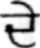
ਦੇ
